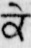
ਕੇ
